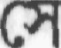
সে
